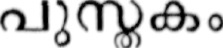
പുസ്തകം
